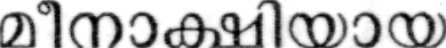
മീനാക്ഷിയായ
